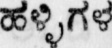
ಹಳ್ಳಿಗಳ
